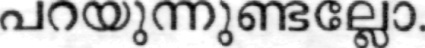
പറയുന്നുണ്ടല്ലോ.
